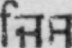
ਜਿਸ
